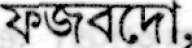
ফজবদো,
